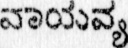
ವಾಯವ್ಯ
